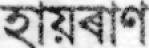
হায়ৰাণ
